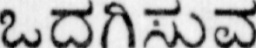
ಒದಗಿಸುವ
